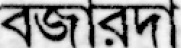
বজারদা
